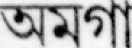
অমগা
